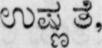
ಉಷ್ಣತೆ,
